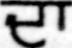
ਦਾ
